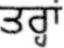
ਤਰ੍ਹਾਂ
